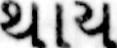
થાય
